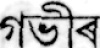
গভীৰ
